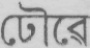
ঢৌৱে
